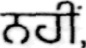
ਨਹੀਂ,
